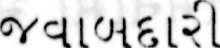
જવાબદારી
